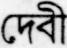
দেবী
